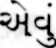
એવું
